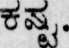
ಕಷ್ಟ.
